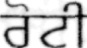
ਰੋਟੀ
